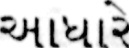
આધારે
